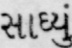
સાઘ્યું
